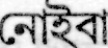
নোইবা
